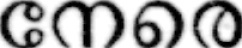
നേരെ
